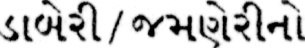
ડાબેરી/જમણેરીનો
